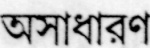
অসাধারণ
